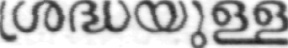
ശ്രദ്ധയുള്ള
